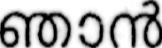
ഞാന്‍
